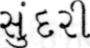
સુંદરી
